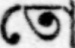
তো
